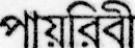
পায়রিবী
